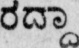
ರದ್ದಾ
